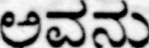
ಅವನು
